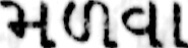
મળવા
